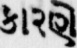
કારણે
